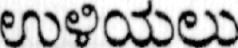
ಉಳಿಯಲು
